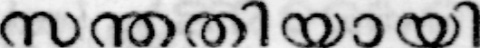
സന്തതിയായി
